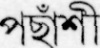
পছাঁশী
